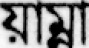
য়াম্না
